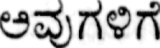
ಅವುಗಳಿಗೆ
